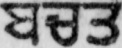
ਬਚਤ
